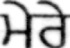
ਮੇਰੇ
